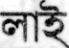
লাই
